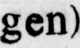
gen)
